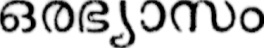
ഒരഭ്യാസം
